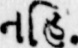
નહિ.
